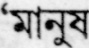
‘মানুষ
